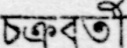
চক্রবর্তী
